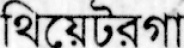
থিয়েটরগা
